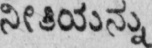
ನೀತಿಯನ್ನು
